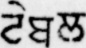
ਟੇਬਲ
